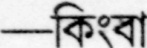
–কিংবা
